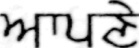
ਆਪਣੇ
